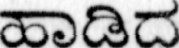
ಹಾಡಿದ
